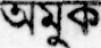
অমুক
